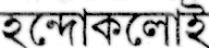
হন্দোকলোই
